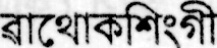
ৱাথোকশিংগী
